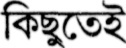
কিছুতেই
